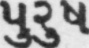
પુરુષ
